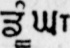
ਡੂੰਘਾ
